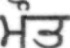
ਮੌਤ
